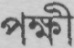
পক্ষী
